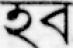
হব
